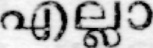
എല്ലാ
